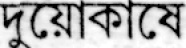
দুয়োকাষে
